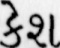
કેશ
